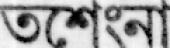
তশেংনা
